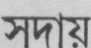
সদায়
